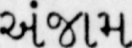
અંજામ
